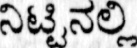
ನಿಟ್ಟಿನಲ್ಲಿ
